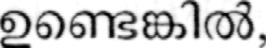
ഉണ്ടെങ്കില്‍,
